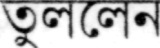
তুললেন
